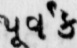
પૂર્વક
